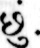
છું
